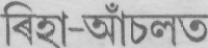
ৰিহা-আঁচলত
